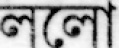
ললো
